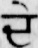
ਦੇ
